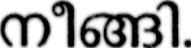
നീങ്ങി.
